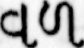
વળ
